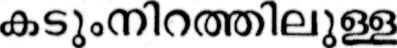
കടുംനിറത്തിലുള്ള
